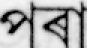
পৰা
